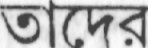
তাদের
